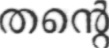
തന്റെ
